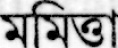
মমিত্তা
